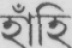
হাঁহি
